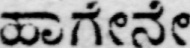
ಹಾಗೇನೇ
